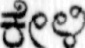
ಕೇಳಿ
